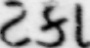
ટકા
